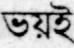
ভয়ই
